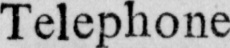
Telephone
